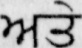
ਅਤੇ
